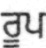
ਰੂਪ
